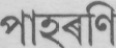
পাহৰণি
